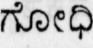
ಗೋಧಿ
